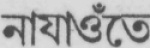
নাযাওঁতে
